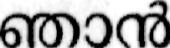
ഞാന്‍
